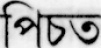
পিচত
